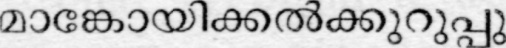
മാങ്കോയിക്കല്‍ക്കുറുപ്പു
